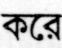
করে
